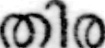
തിര
